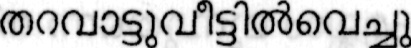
തറവാട്ടുവീട്ടില്‍വെച്ചു
